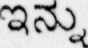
ಇನ್ನು
